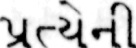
પ્રત્યેની
